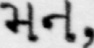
મન,
